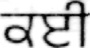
ਕਈ
